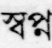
স্বপ্ন
